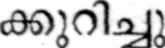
ക്കുറിച്ചു
